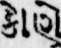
કોણે
